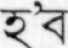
হ'ব
